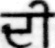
ਦੀ
